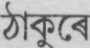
ঠাকুৰে
